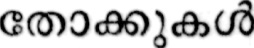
തോക്കുകള്‍
